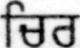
ਚਿਰ
